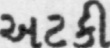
અટકી
